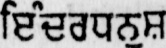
ਇੰਦਰਧਨੁਸ਼
